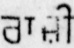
ਰਾਜ਼ੀ
